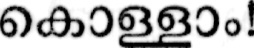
കൊള്ളാം!
